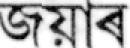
জয়াৰ
